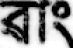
ৱাং
